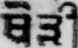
ਥੋੜੀ
